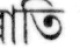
ৰাতি
